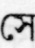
সে
